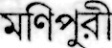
মণিপুরী
